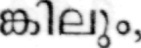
ങ്കിലും,
